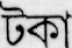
টকা
